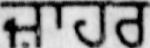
ਜ਼ਾਹਰ
